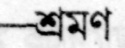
–শ্রমণ
